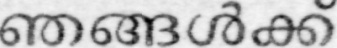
ഞങ്ങള്‍ക്ക്
